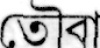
তৌবা
